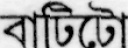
বাটিটো
